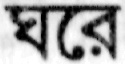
ঘরে
